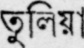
তুলিয়া
